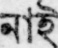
নাই
